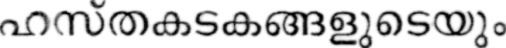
ഹസ്തകടകങ്ങളുടെയും
